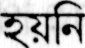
হয়নি
